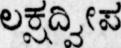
ಲಕ್ಷದ್ವೀಪ
